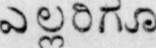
ಎಲ್ಲರಿಗೂ
